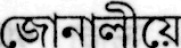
জোনালীয়ে
